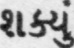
શક્યું
